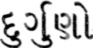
દુર્ગુણો
